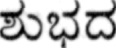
ಶುಭದ
